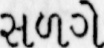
સળગે
